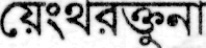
য়েংথরক্তুনা
